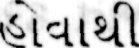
હોવાથી
